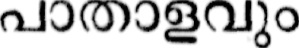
പാതാളവും
